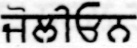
ਜੋਲੀਓਨ
